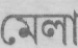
মেলা
